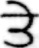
ਤੇ
